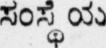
ಸಂಸ್ಥೆಯ
